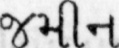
જમીન
